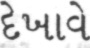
દેખાવે
